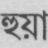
হুয়া
